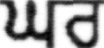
ਘਰ
